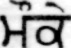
ਮੌਕੇ
